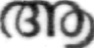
ആ
